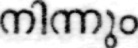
നിന്നും
